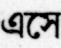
এসে
